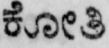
ಕೋತಿ
